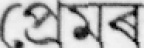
প্রেমৰ
